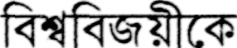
বিশ্ববিজয়ীকে
